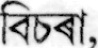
বিচৰা,
